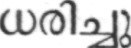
ധരിച്ചു
